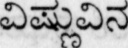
ವಿಷ್ಣುವಿನ
